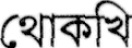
থোকখি
